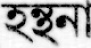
হন্থনা
